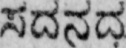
ಸದನದ
